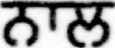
ਨਾਲ
